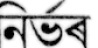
নির্ভৰ
